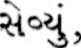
સેવ્યું,
